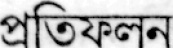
প্রতিফলন
